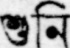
শুনি
